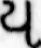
ય
